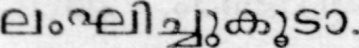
ലംഘിച്ചുകൂടാ.
